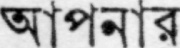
আপনার
